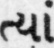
ત્યાં
